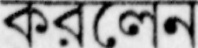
করলেন
